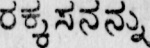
ರಕ್ಕಸನನ್ನು
